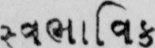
સ્વભાવિક
